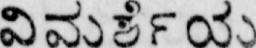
ವಿಮರ್ಶೆಯ
